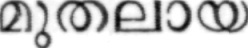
മുതലായ
